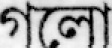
গলো
